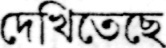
দেখিতেছে
